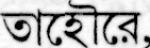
তাহৌরে,
